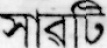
সাৱটি
